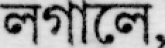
লগালে,
